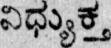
ವಿಧ್ಯುಕ್ತ
